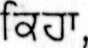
ਕਿਹਾ,
